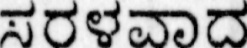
ಸರಳವಾದ
